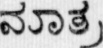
ಮಾತ್ರ
